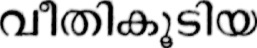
വീതികൂടിയ
